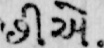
છીએ.
